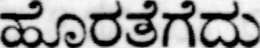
ಹೊರತೆಗೆದು
